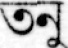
তনু
